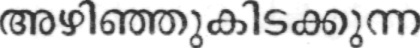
അഴിഞ്ഞുകിടക്കുന്ന
